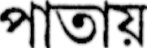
পাতায়
